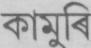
কামুৰি
